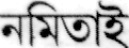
নমিতাই
